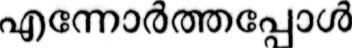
എന്നോര്‍ത്തപ്പോള്‍
